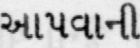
આપવાની
